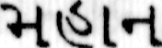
મહાન
